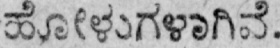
ಹೋಳುಗಳಾಗಿವೆ.
